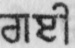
ਗਈ
